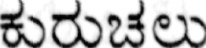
ಕುರುಚಲು
